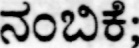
ನಂಬಿಕೆ;
